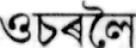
ওচৰলৈ
